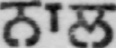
ਨਾਲ
